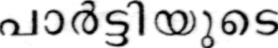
പാര്‍ട്ടിയുടെ
